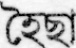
হৈছা
